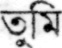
তুমি
